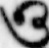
ও
